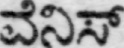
ವೆನಿಸ್
